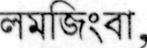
লমজিংবা,
